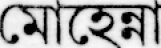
মোহেন্না
